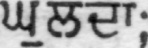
ਘੁਲਦਾ;
